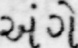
અંગે
